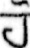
ਹੋ
